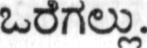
ಒರೆಗಲ್ಲು.
